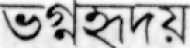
ভগ্নহৃদয়
